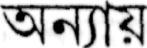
অন্যায়
